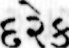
દરેક
